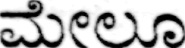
ಮೇಲೂ
